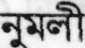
নুমলী
